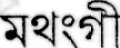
মথংগী
